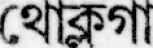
থোক্লগা
